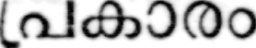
പ്രകാരം
